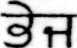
ਭੇਜ
